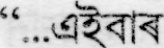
"...এইবাৰ
